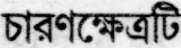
চারণক্ষেত্রটি
